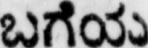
ಬಗೆಯ
